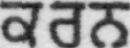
ਕਰਨ
